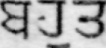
ਬਹੁਤ
